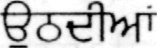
ਉਠਦੀਆਂ
